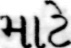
માટે
